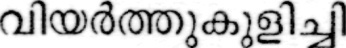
വിയര്‍ത്തുകുളിച്ചി
